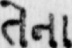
તેના
